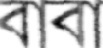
বাবা
